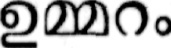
ഉമ്മറം
